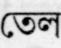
তেল
